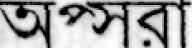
অপ্সরা
